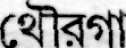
থৌরগা
